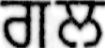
ਗਲ
